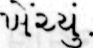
ખેંચ્યું.
